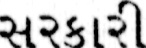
સરકારી
